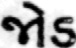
જોડ
